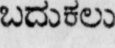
ಬದುಕಲು
